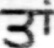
ਤਾਂ
